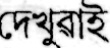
দেখুৱাই
